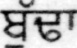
ਬੁੱਢਾ
